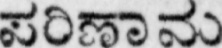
ಪರಿಣಾಮ
